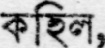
কহিল,
